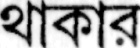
থাকার
